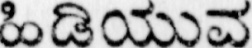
ಹಿಡಿಯುವ
